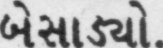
બેસાડ્યો.
